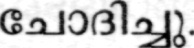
ചോദിച്ചു.
